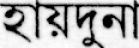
হায়দুনা
